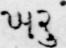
ખરું
